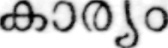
കാര്യം
